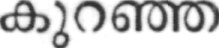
കുറഞ്ഞ
